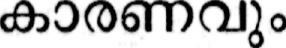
കാരണവും
